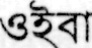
ওইবা
